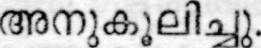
അനുകൂലിച്ചു.
